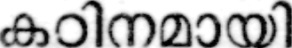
കഠിനമായി
